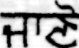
ਜਾਣੋ
